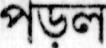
পড়ল
